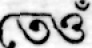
তেওঁ
